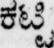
ಕಟ್ಟಿ
